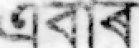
এবাৰ
